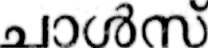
ചാള്‍സ്
